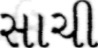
સાચી
